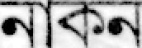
নাকন
